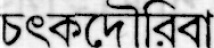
চৎকদৌরিবা
